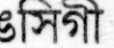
ঙসিগী
